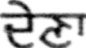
ਦੇਣਾ
